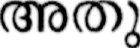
അതു
